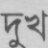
দুখ
